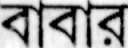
বাবার
